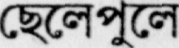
ছেলেপুলে
